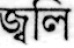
জ্বলি
